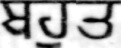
ਬਹੁਤ
